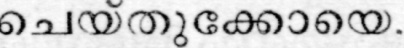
ചെയ്തുക്കോയെ.
